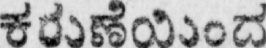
ಕರುಣೆಯಿಂದ
